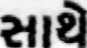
સાથે
